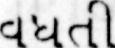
વધતી
